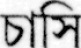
চাসি
